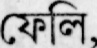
ফেলি,
